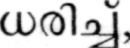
ധരിച്ച്,
